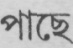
পাছে
